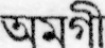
অমগী
